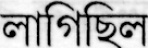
লাগিছিল
